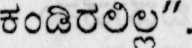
ಕಂಡಿರಲಿಲ್ಲ”.
